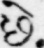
છે.
